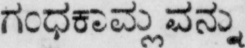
ಗಂಧಕಾಮ್ಲವನ್ನು
